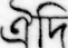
ঐদি
